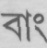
বাং
